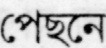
পেছনে
